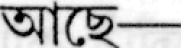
আছে-
